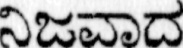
ನಿಜವಾದ
